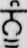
ਨੂੰ
